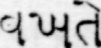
વખતે
